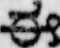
ಈ
